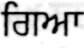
ਗਿਆ
